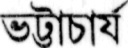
ভট্টাচার্য
